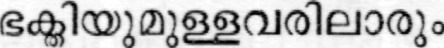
ഭക്തിയുമുള്ളവരിലാരും
